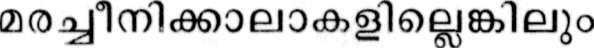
മരച്ചീനിക്കാലാകളില്ലെങ്കിലും
